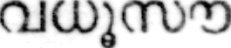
വധൂസൌ
